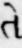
તે
